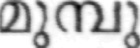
മുമ്പു
